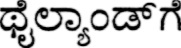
ಥೈಲ್ಯಾಂಡ್ ಗೆ
